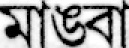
মাঙবা
